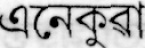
এনেকুৱা
